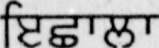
ਇਛਾਲਾ
